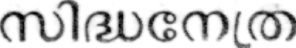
സിദ്ധനേത്ര
